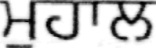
ਮੁਹਾਲ
